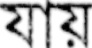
যায়
